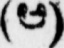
(ಆ)
